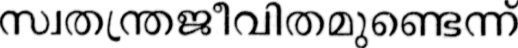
സ്വതന്ത്രജീവിതമുണ്ടെന്ന്
